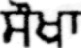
ਸੌਖਾ
